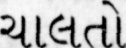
ચાલતો
